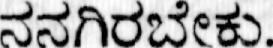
ನನಗಿರಬೇಕು.
